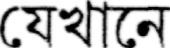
যেখানে
